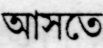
আসতে
